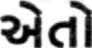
એતો
